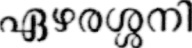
ഏഴരശ്ശനി
